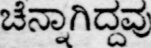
ಚೆನ್ನಾಗಿದ್ದವು
